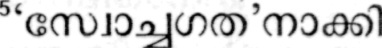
5'സ്വോച്ചഗത'നാക്കി
